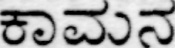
ಕಾಮನ
